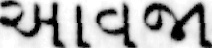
આવજા
